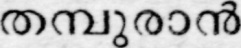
തമ്പുരാന്‍
